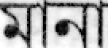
মানা
